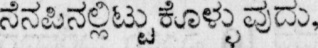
ನೆನಪಿನಲ್ಲಿಟ್ಟುಕೊಳ್ಳುವುದು.
